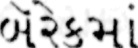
બૅરેકમાં
